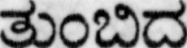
ತುಂಬಿದ
